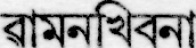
ৱামনখিবনা
